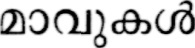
മാവുകള്‍
